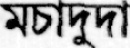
মচাদুদা
